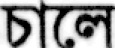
চালে
